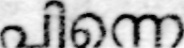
പിന്നെ
